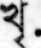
খৃ.
